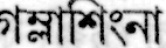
গম্লাশিংনা
